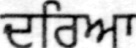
ਦਰਿਆ
